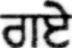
ਗਏ
